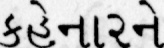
કહેનારને
